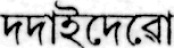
দদাইদেৱো
